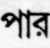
পার
